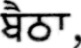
ਬੈਠਾ,
